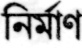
নির্মাণ
